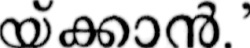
യ്ക്കാന്‍.’
